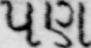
પણ
